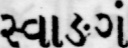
સ્વાઙગં
